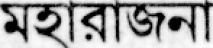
মহারাজনা
